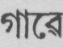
গাৱে
